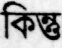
কিন্তু
